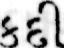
કદી
